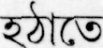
হঠাতে
